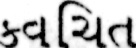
ક્વચિત
